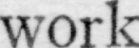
work
